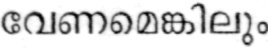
വേണമെങ്കിലും
